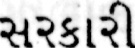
સરકારી
